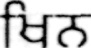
ਖਿਨ
